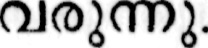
വരുന്നു.
